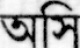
অসি
